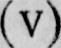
(v)
